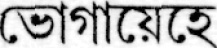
ভোগায়েহে
